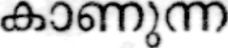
കാണുന്ന
